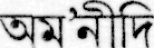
অম’নীদি
